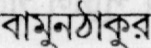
বামুনঠাকুর
